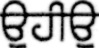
ਉਹੀਉ
